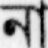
না
